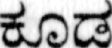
ಕೂಡ
